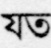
যত
